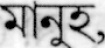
মানুহ,
